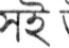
সেই
